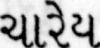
ચારેય
